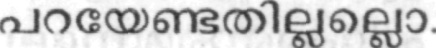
പറയേണ്ടതില്ലല്ലൊ.
